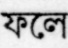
ফলে
